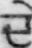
ਦੇ
